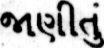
જાણીતું
